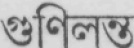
গুণিলন্ত
